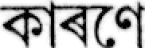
কাৰণে
